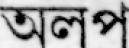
অলপ
